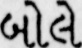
બોલે
